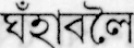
ঘঁহাবলৈ
